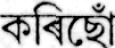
কৰিছোঁ
